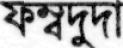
ফম্বদুদা
